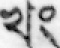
খং
